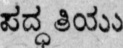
ಪದ್ಧತಿಯು
